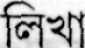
লিখা
